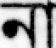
না
